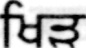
ਖਿੜ
